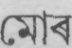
মোৰ
